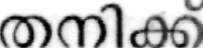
തനിക്ക്
